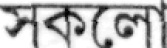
সকলো
